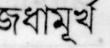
জধামূৰ্খ
